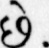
છે.
